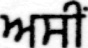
ਅਸੀਂ
